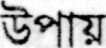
উপায়
